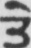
ਤੇ
